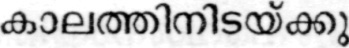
കാലത്തിനിടയ്ക്ക്
